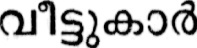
വീട്ടുകാര്‍
